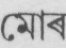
মোৰ
